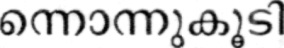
ന്നൊന്നുകൂടി
